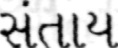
સંતાય
